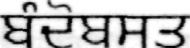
ਬੰਦੋਬਸਤ
